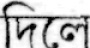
দিলে
